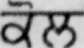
ਕੋਲ
